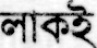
লাকই
